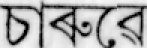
চাৰুৱে
